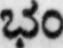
ಭಂ
